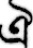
ঐ
